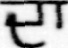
ਦਾ
